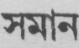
সমান
